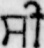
ਸੀ
